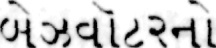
બેઝવૉટરનો
